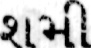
શમી
